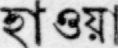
হাওয়া
